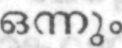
ഒന്നും
